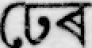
ঢেৰ
